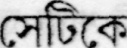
সেটিকে
